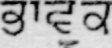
ਭਾਵੁਕ
